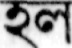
হল
